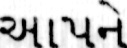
આપને
